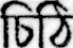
চিঠি
